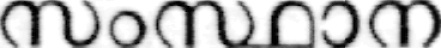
സംസ്ഥാന
